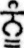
ਨੂੰ
